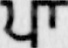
ਪਾ
